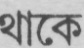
থাকে
